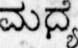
ಮದ್ಯೆ
